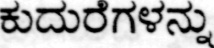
ಕುದುರೆಗಳನ್ನು
